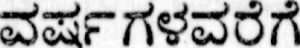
ವರ್ಷಗಳವರೆಗೆ
